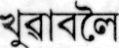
খুৱাবলৈ
